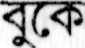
বুকে
